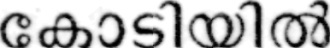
കോടിയില്‍
